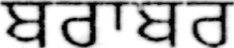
ਬਰਾਬਰ
